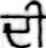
ਦੀ
